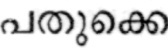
പതുക്കെ
